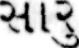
સારુ
